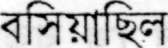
বসিয়াছিল
